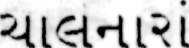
ચાલનારાં
